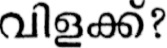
വിളക്ക്?
